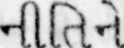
નીતિને
